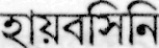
হায়বসিনি
